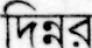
দিন্নর
